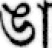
ঙা
